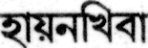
হায়নখিবা
